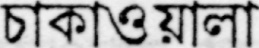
চাকাওয়ালা
